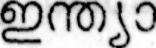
ഇന്ത്യാ
